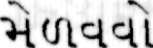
મેળવવો
